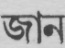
জান
